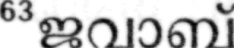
63ജവാബ്
